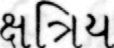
ક્ષત્રિય
